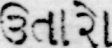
ઉતારો
